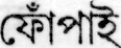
ফোঁপাই
